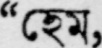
‘‘হেম,
